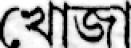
খোজা
